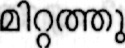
മിറ്റത്തു
